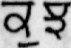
ਕੁਝ
